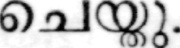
ചെയ്തു.
